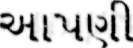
આપણી
